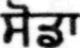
ਸੋਡਾ
